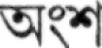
অংশ
